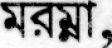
মরম্না,
